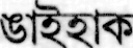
ঙাইহাক
